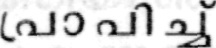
പ്രാപിച്ച്
